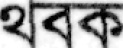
থবক
